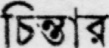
চিন্তার
